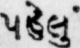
પહેલું
